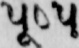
પૂષ્પ
